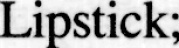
Lipstick;
